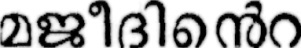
മജീദിന്റെ
